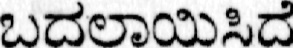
ಬದಲಾಯಿಸಿದೆ
